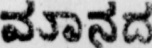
ಮಾನದ
